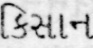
કિસાન
